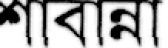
শাবান্না
